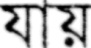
যায়
